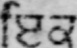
ਇਕ
